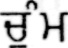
ਚੁੰਮ
